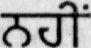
ਨਹੀਂ
